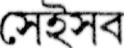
সেইসব
